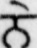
ਨੇ
